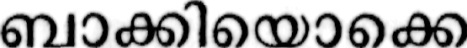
ബാക്കിയൊക്കെ
